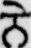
ਨੇ
